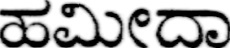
ಹಮೀದಾ
